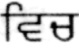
ਵਿਚ
